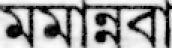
মমান্নবা
